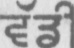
ਵੱਡੀ
